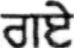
ਗਏ
